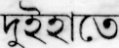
দুইহাতে
